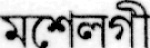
মশেলগী
